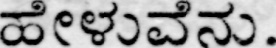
ಹೇಳುವೆನು.
